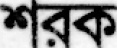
শরক
